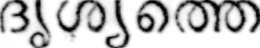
ദൃശ്യത്തെ
